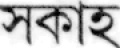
সকাহ
